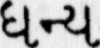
ધન્ય
